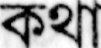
কথা
